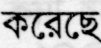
করেছে
